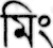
মিং
